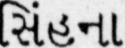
સિંહના
